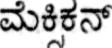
ಮೆಕ್ಸಿಕನ್
